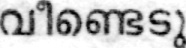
വീണ്ടെടു
